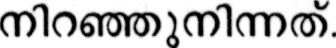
നിറഞ്ഞുനിന്നത്.
